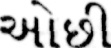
ઓછી
